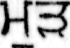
ਮੁੜ
